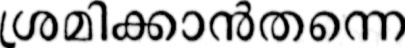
ശ്രമിക്കാന്‍തന്നെ
